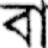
বা
